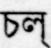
চল্
